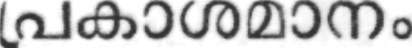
പ്രകാശമാനം
